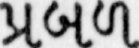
પ્રબળ
